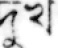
দুখ
